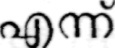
എന്ന്
